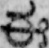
ಈ
